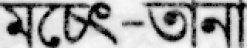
মচেৎ-তানা
